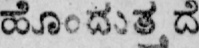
ಹೊಂದುತ್ತದೆ
